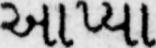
આપ્યા
